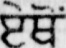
ਏਥੋਂ
